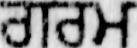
ਗਰਮ
